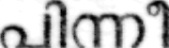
പിന്നീ
